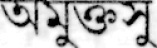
অমুক্তসু
